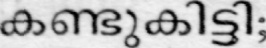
കണ്ടുകിട്ടി;
